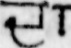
ਦਾ
